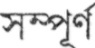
সম্পূর্ণ
